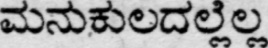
ಮನುಕುಲದಲ್ಲೆಲ್ಲ
